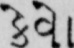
કેવો
